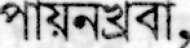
পায়নখ্রবা,
